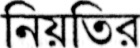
নিয়তির
